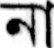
না
